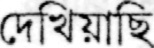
দেখিয়াছি
